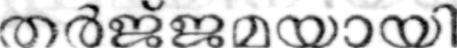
തര്‍ജ്ജമയായി
